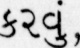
કરવું,
